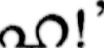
ഹ!'
